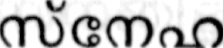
സ്നേഹ
